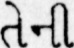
તેની
